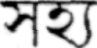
সহ্য
